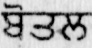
ਬੋਤਲ
